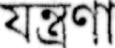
যন্ত্রণা
